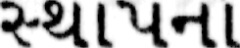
સ્થાપના
